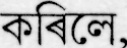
কৰিলে,
